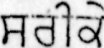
ਸਰੀਕੇ
